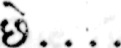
છે....
